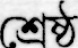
শ্রেষ্ঠ
